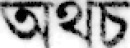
অথচ
